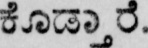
ಕೊಡ್ತಾರೆ.
